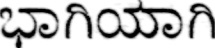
ಭಾಗಿಯಾಗಿ
